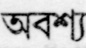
অবশ্য
